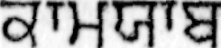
ਕਾਮਯਾਬ
